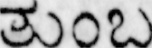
ತುಂಬ
